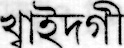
খ্বাইদগী
